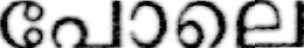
പോലെ
